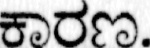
ಕಾರಣ.
